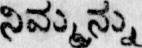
ನಿಮ್ಮನ್ನು
